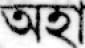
অহা
